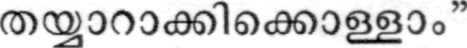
തയ്യാറാക്കിക്കൊള്ളാം”
